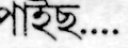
পাইছ....
